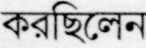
করছিলেন
